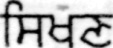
ਸਿਖਣ
